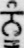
ਨੂੰ
